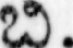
ಬಿ.
